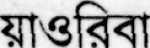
য়াওরিবা
